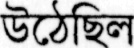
উঠেছিল
